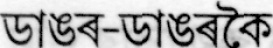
ডাঙৰ-ডাঙৰকৈ
